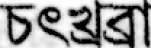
চৎখ্রব্রা
